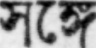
সঙ্গে
